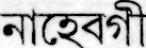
নাহেবগী
